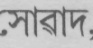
সোৱাদ,
